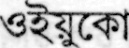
ওইয়ুকো
